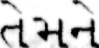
તેમને
